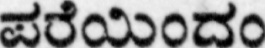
ಪರೆಯಿಂದಂ
